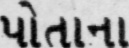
પોતાના
